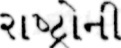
રાષ્ટ્રોની
